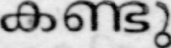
കണ്ടു
